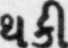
થકી
